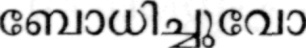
ബോധിച്ചുവോ
